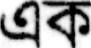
এক
